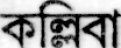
কল্লিবা
